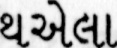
થએલા
